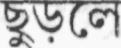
ছুড়লে
